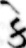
કે
